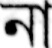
না
